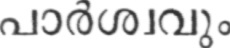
പാര്‍ശ്വവും
